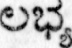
ಲಭ್ಯ
